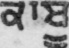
ਕਾਬੂ
